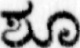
ಶೂ
